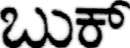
ಬುಕ್
